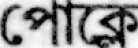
পোক্লে
